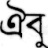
ঐবু
